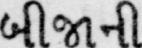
બીજાની
